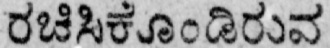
ರಚಿಸಿಕೊಂಡಿರುವ
